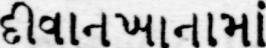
દીવાનખાનામાં
